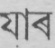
যাৰ
